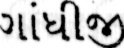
ગાંધીજી
